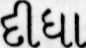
દીધા
